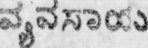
ವ್ಯವಸಾಯ
